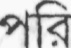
পরি
